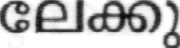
ലേക്കു
